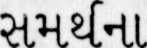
સમર્થના
